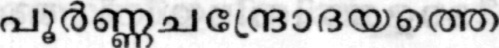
പൂര്‍ണ്ണചന്ദ്രോദയത്തെ
